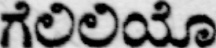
ಗೆಲಿಲಿಯೊ
